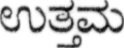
ಉತ್ತಮ
